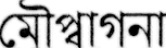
মৌপ্বাগনা
